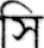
সি
